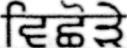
ਵਿਛੋੜੇ
